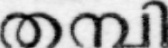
തമ്പി
